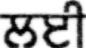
ਲਈ
